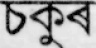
চকুৰ
